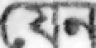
যেন
